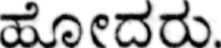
ಹೋದರು.
